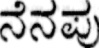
ನೆನಪು
